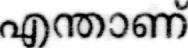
എന്താണ്
